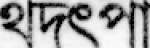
থদৎপা
